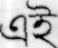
এই
